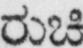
ರುಚಿ
